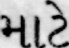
માટે
